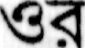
ওর
